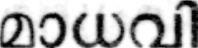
മാധവി
